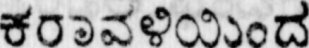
ಕರಾವಳಿಯಿಂದ
